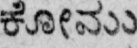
ಕೋಮು
